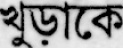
খুড়াকে
